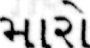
મારો
